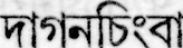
দাগনচিংবা
